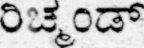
ರಿಚ್ಮಂಡ್
